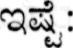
ಇಷ್ಟೆ:
